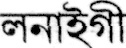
লনাইগী
